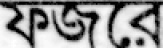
ফজরে
